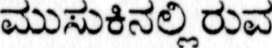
ಮುಸುಕಿನಲ್ಲಿರುವ
